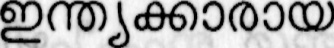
ഇന്ത്യക്കാരായ
